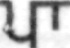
ਪਾ
